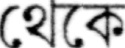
থেকে
